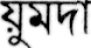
য়ুমদা
